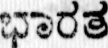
ಭಾರತ
